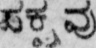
ಪಕ್ಷವು
